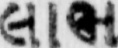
લાભ
